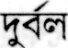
দুর্বল
